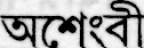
অশেংবী
